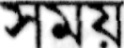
সময়
